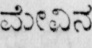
ಮೇವಿನ
